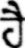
ਹੈ
